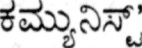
ಕಮ್ಯುನಿಸ್ಟ್'
